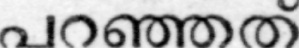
പറഞ്ഞത്
